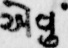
એવું
